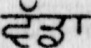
ਵੱਡਾ
